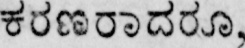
ಕರಣರಾದರೂ,
